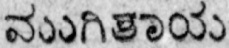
ಮುಗಿತಾಯ
